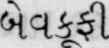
બેવકૂફી
